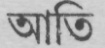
আতি
